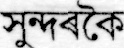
সুন্দৰকৈ
